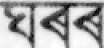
ঘৰৰ
